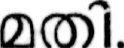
മതി.
